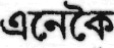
এনেকৈ
